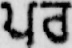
ਪਰ
